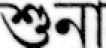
শুনা
